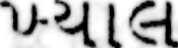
ખ્યાલ
